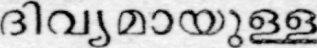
ദിവ്യമായുള്ള
